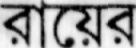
রায়ের
